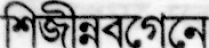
শিজীন্নবগেনে
